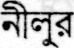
নীলুর
